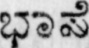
ಭಾಷೆ
